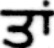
ਤਾਂ
